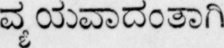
ವ್ಯಯವಾದಂತಾಗಿ
